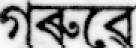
গৰুৱে
